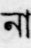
না
